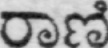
ರಾಣಿ
